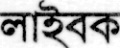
লাইবক
